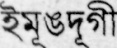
ইমূঙদূগী
